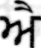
ਐ
